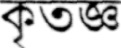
কৃতজ্ঞ
